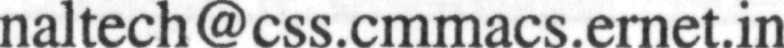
naltech@css.cmmacs.ernet.in
